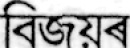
বিজয়ৰ
